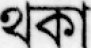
থকা
